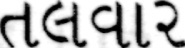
તલવાર
